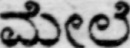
ಮೇಲೆ
